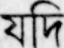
যদি
